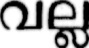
വല്ല
